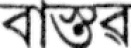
বাস্তৱ
